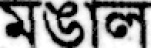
মঙাল
